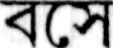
বসে
